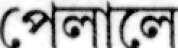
পেলালে
